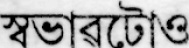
স্বভাৱটোও
